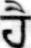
ਹੈ
